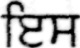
ਇਸ
